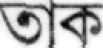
তাক
